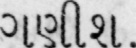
ગણીશ.
